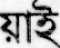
য়াই
